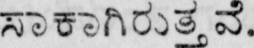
ಸಾಕಾಗಿರುತ್ತವೆ.
